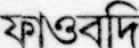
ফাওবদি
